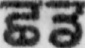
ਛਡ
